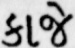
કાજે
